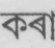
কৰা
